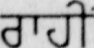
ਰਾਹੀਂ
